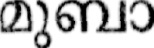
മുബാ
